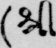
(શ્રી
